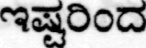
ಇಷ್ಟರಿಂದ
